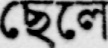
ছেলে
